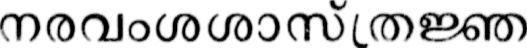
നരവംശശാസ്ത്രജ്ഞ
